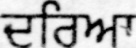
ਦਰਿਆ
